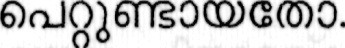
പെറ്റുണ്ടായതോ.
